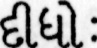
દીધો:
